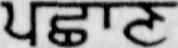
ਪਛਾਣ
